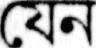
যেন
